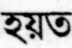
হয়ত
